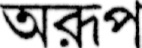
অরূপ
